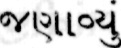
જણાવ્યું
